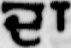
ਦਾ
